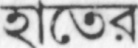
হাতের
